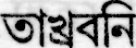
তাখ্রবনি
